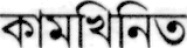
কামখিনিত
